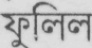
ফুলিল
